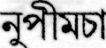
নুপীমচা
